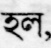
হল,
